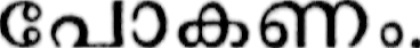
പോകണം.
